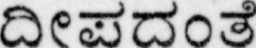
ದೀಪದಂತೆ
